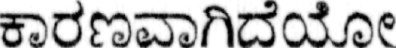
ಕಾರಣವಾಗಿದೆಯೋ
